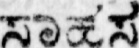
ಸಾಹಸ
